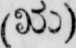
(ಋ)
